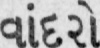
વાંદરો
